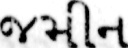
જમીન
